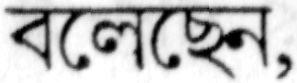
বলেছেন,
